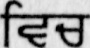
ਵਿਚ
